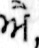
ਐ,
